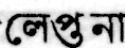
লেপ্তনা
